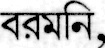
বরমনি,
